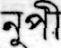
নুপী
